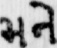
મને
